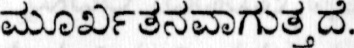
ಮೂರ್ಖತನವಾಗುತ್ತದೆ.
